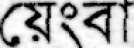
য়েংবা
